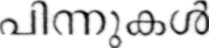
പിന്നുകള്‍
